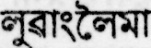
লুৱাংলৈমা
